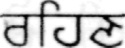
ਰਹਿਣ
